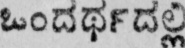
ಒಂದರ್ಥದಲ್ಲಿ
